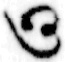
ও
